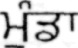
ਮੁੰਡਾ
